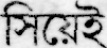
সিয়েই
